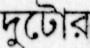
দুটোর
